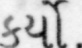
કર્યો.
